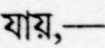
যায়,–
